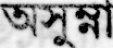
অসুম্না
